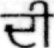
ਦੀ
